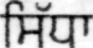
ਸਿੱਧਾ
